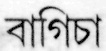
বাগিচা
